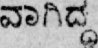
ವಾಗಿದ್ದ
